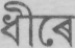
ধীৰে
